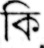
কি
